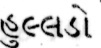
હુલ્લડો
